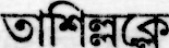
তাশিল্লক্লে
